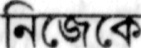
নিজেকে
